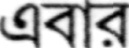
এবার
